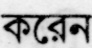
করেন
